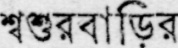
শ্বশুরবাড়ির
